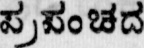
ಪ್ರಪಂಚದ
